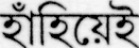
হাঁহিয়েই
